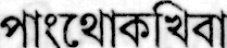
পাংথোখিবা
